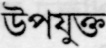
উপযুক্ত
